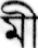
মী
